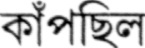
কাঁপছিল
